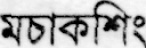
মচাকশিং
